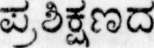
ಪ್ರಶಿಕ್ಷಣದ
